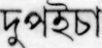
দুপইচা
